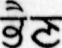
ਭੈਣ
